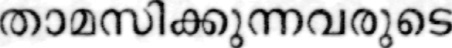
താമസിക്കുന്നവരുടെ
